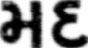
મદ
